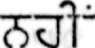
ਨਹੀਂ
